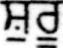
ਸ਼ੁਰੂ
